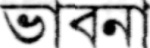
ভাবনা
